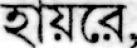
হায়রে,
